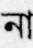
না
